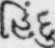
હિંદુ
